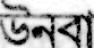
উনবা
